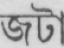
জটা
